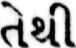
તેથી
